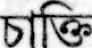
চাক্তি
